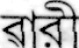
ৱারী
